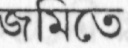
জমিতে
